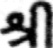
શ્રી
